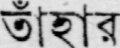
তাঁহার
